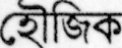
হৌজিক
